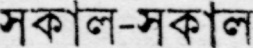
সকাল-সকাল
